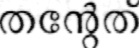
തന്റേത്
